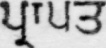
ਪ੍ਰਾਪਤ
